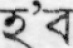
হ'ব
